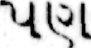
પણ
